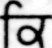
ਕਿ
